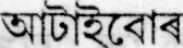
আটাইবোৰ
